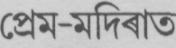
প্ৰেম-মদিৰাত
